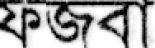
ফজবা
